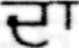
ਦਾ
